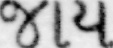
જાય
